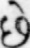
છે
